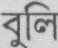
বুলি
